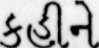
કહીને
